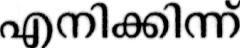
എനിക്കിന്ന്
